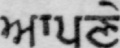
ਆਪਣੇ
